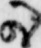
જે
